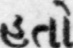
હતો
